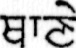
ਥਾਣੇ
